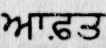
ਆਫ਼ਤ
